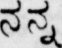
ನನ್ನ
